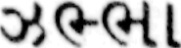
ઝભ્ભા
